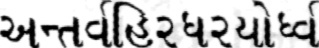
અન્ત્વહિરધરયોધવ
